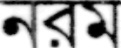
নরম
